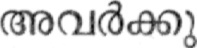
അവര്‍ക്കു
